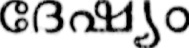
ദേഷ്യം
